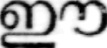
ഈ
